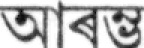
আৰম্ভ
